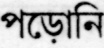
পড়োনি
